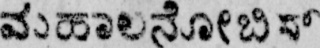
ಮಹಾಲನೋಬಿಸ್
